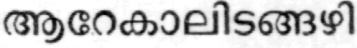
ആറേകാലിടങ്ങഴി
